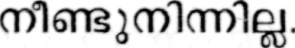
നീണ്ടുനിന്നില്ല.
